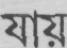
যায়
